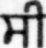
ਸੀ
